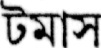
টমাস
